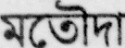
মতৌদা
